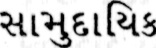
સામુદાયિક
